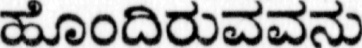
ಹೊಂದಿರುವವನು
